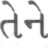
તેને
